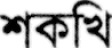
শকখি
